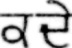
ਕਦੇ
